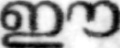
ഈ
